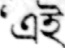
‘এই
